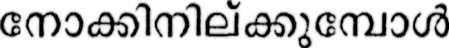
നോക്കിനില്ക്കുമ്പോള്‍
